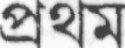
প্রথম
